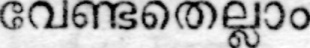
വേണ്ടതെല്ലാം
